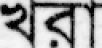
খরা
